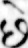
છે
